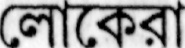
লোকেরা
